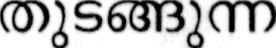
തുടങ്ങുന്ന
